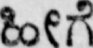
ಹೀಗೆ
